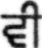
ਵੀ
